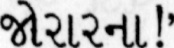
જોરારના!'
